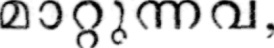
മാറ്റുന്നവ,
